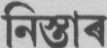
নিস্তাৰ
